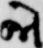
જો
